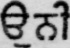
ਉਨੀ
